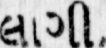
લાગી.
